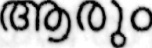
ആരും
